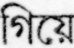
গিয়ে
